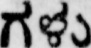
ಗಳು
